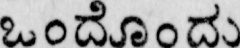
ಒಂದೊಂದು
